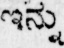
ಇನ್ನು
